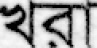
খরা
